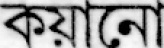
কয়ানো
